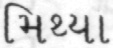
મિથ્યા
